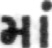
માં
